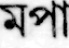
মপা
